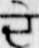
ਦੇ
